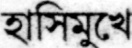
হাসিমুখে
